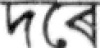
দৰে
